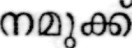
നമുക്ക്
